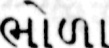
ભોળા
